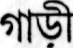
গাড়ী
